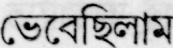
ভেবেছিলাম
